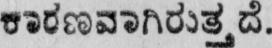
ಕಾರಣವಾಗಿರುತ್ತದೆ.
